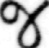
જ
